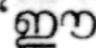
‘ഈ
